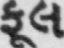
ફૂલ
